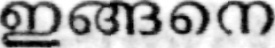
ഇങ്ങനെ
